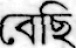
বেছি
